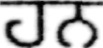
ਹਨ
